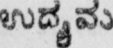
ಉದ್ಯಮ
